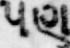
પણ
